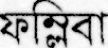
ফম্লিবা
